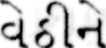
વેઠીને
